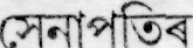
সেনাপতিৰ
